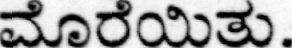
ಮೊರೆಯಿತು.
